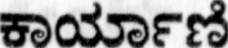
ಕಾರ್ಯಾಣಿ
